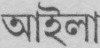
আইলা
